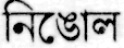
নিঙোল
